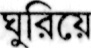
ঘুরিয়ে
